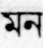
মন
